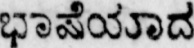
ಭಾಷೆಯಾದ
